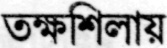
তক্ষশিলায়
